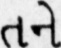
તને
